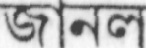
জানল
